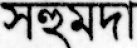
সাহুমদা
